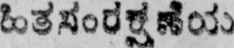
ಹಿತಸಂರಕ್ಷಣೆಯ
